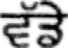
ਵੱਡੇ
